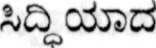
ಸಿದ್ಧಿಯಾದ
